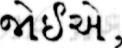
જોઈએ,
